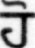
ਹੋ
